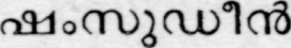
ഷംസുഡീന്‍
